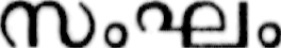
സംഘം
